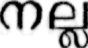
നല്ല
